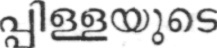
പ്പിള്ളയുടെ
